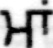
ਮਾਂ
